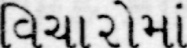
વિચારોમાં
